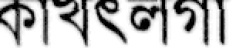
কাখৎলগা
